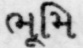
ભૂમિ
